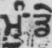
ਮੁੰਡੇ
